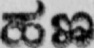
ಹಣ
